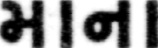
માના
